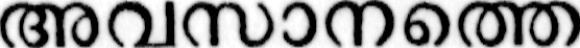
അവസാനത്തെ
